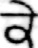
ਕੇ
